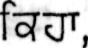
ਕਿਹਾ,
